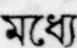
মধ্যে
